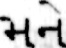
મને
